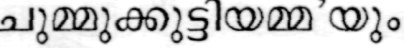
ചുമ്മുക്കുട്ടിയമ്മ’യും
